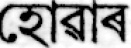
হোৱাৰ
